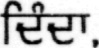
ਦਿੰਦਾ,
